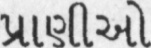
પ્રાણીઓ
